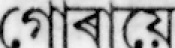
গোৰায়ে
